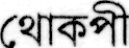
থোকপী
